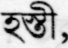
হস্তী,
